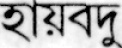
হায়বদু
